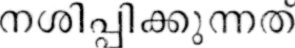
നശിപ്പിക്കുന്നത്
